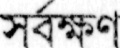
সর্বক্ষণ
